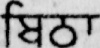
ਬਿਠਾ
